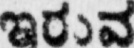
ಇರುವ
